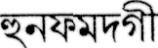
হুনফমদগী
